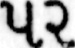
પર
